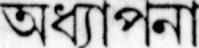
অধ্যাপনা
